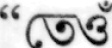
"তেওঁ
